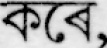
কৰে,
